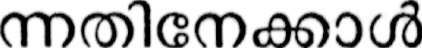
ന്നതിനേക്കാള്‍
